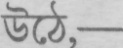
উঠে,-
